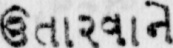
ઉતારવાને
